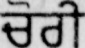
ਚੋਰੀ
